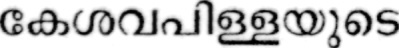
കേശവപിള്ളയുടെ
